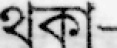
থকা-
